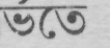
গৰ্ভতে
